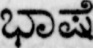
ಭಾಷೆ
